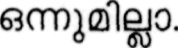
ഒന്നുമില്ലാ.
